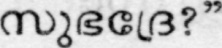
സുഭദ്രേ?”
